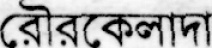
রৌরকেলাদা
